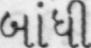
બાંધી
